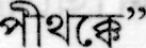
পীথক্কে”
